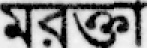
মরক্তা
